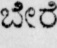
ಬೇರೆ
